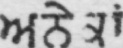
ਅਨੇਕਾਂ
